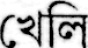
খেলি
